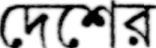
দেশের
